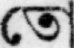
তো
